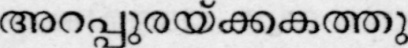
അറപ്പുരയ്ക്കകത്തു
